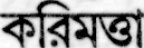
করিমত্তা
